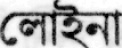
লোইনা
